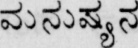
ಮನುಷ್ಯನ
